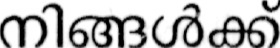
നിങ്ങള്‍ക്ക്
